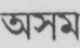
অসম
